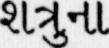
શત્રુના
